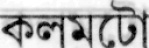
কলমটো
